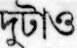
দুটাও
